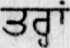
ਤਰ੍ਹਾਂ
